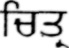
ਚਿਤ੍ਰ
